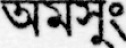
অমসুং
